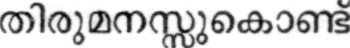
തിരുമനസ്സുകൊണ്ട്
